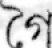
গৈ
